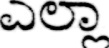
ಎಲ್ಲಾ
